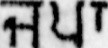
ਜਪਾ
